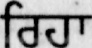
ਰਿਹਾ
